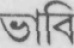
ভাবি
